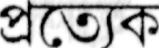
প্রত্যেক
